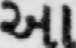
આ
